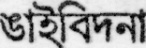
ঙাইবিদনা
